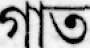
গাত
